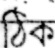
ঠিক
